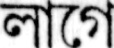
লাগে
